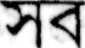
সব
